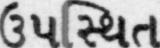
ઉપસ્થિત
